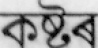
কষ্টৰ
